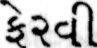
ફેરવી
